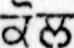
ਕੋਲ
